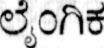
ಲೈಂಗಿಕ
